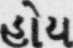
હોય
